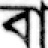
বা
